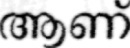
ആണ്
